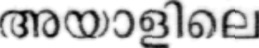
അയാളിലെ
